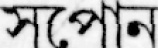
সপোন
